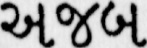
અજબ
